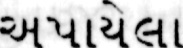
અપાયેલા
